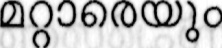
മറ്റാരെയും
